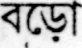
বড়ো
